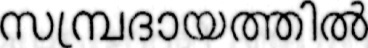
സമ്പ്രദായത്തില്‍
